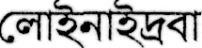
লোইনাইদ্রবা
